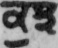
ਕੁਝ
